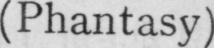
(Phantasy)
